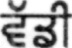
ਵੱਡੀ
